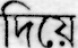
দিয়ে
